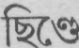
ছিণ্ডে
